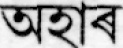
অহাৰ
